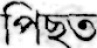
পিছত
